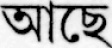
আছে
